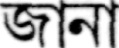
জানা
